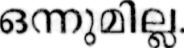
ഒന്നുമില്ല.
